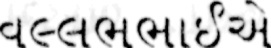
વલ્લભભાઈએ
